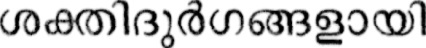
ശക്തിദുര്‍ഗങ്ങളായി
